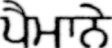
ਪੈਮਾਨੇ
